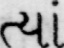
ત્યાં
